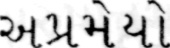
અપ્રમેયો
